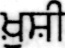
ਖ਼ੁਸ਼ੀ
